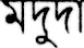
মদুদা
